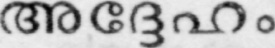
അദ്ദേഹം
